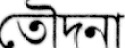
তৌদনা
